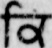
ਕਿ
